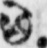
છે.
